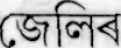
জেলিৰ
